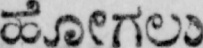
ಹೋಗಲು
